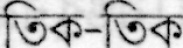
তিক-তিক
